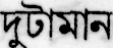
দুটামান
